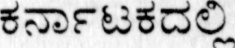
ಕರ್ನಾಟಕದಲ್ಲಿ
